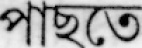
পাছতে
